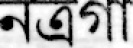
নত্রগা
